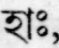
হাঃ,
